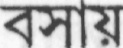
বসায়
